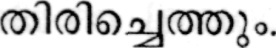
തിരിച്ചെത്തും.
